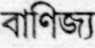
বাণিজ্য
